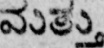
ಮತ್ತು
